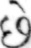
છે
